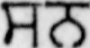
ਸਨ
